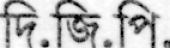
দি.জি.পি.
